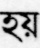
হয়
